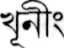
খূনীং
